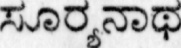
ಸೂರ್‍ಯನಾಥ
